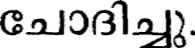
ചോദിച്ചു.
